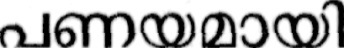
പണയമായി
